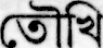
তৌখি
